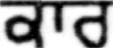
ਕਾਰ
